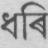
ধৰি
